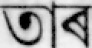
তাৰ
